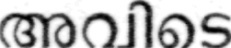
അവിടെ
